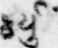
કર્યું
